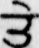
ਤੇ
